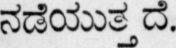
ನಡೆಯುತ್ತದೆ.
